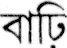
বাঢ়ি
